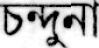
চন্দুনা
